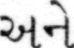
અને
